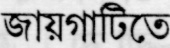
জায়গাটিতে
